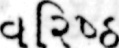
વરિષ્ઠ
